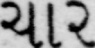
ચાર
